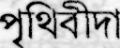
পৃথিবীদা
